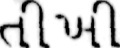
તીખી
